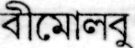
বীমোলবু
